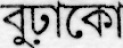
বুঢ়াকো
